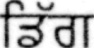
ਡਿੱਗ
